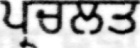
ਪ੍ਰਚਲਤ
